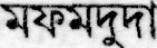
মফমদুদা
